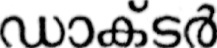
ഡാക്ടര്‍
